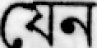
যেন
